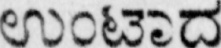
ಉಂಟಾದ
